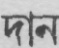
দান
